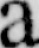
a
